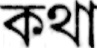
কথা
